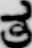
ತ
